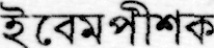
ইবেমপীশক
